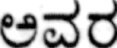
ಅವರ
